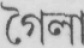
গৈলা
